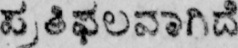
ಪ್ರತಿಫಲವಾಗಿದೆ
